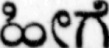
ಹೀಗೆ
